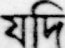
যদি
